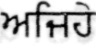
ਅਜਿਹੇ
